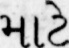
માટે
